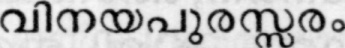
വിനയപുരസ്സരം
